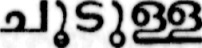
ചൂടുള്ള
